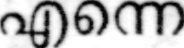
എന്നെ
